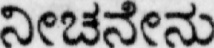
ನೀಚನೇನು
